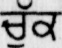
ਚੁੱਕ
